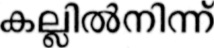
കല്ലില്‍നിന്ന്
